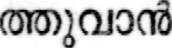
ത്തുവാന്‍
